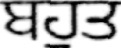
ਬਹੁਤ
